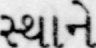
સ્થાને
